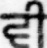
ਵੀ
